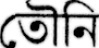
তৌনি
